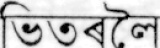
ভিতৰলৈ
